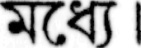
মধ্যে।
